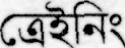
ত্রেইনিং
